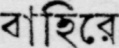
বাহিরে
